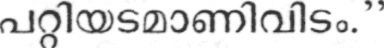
പറ്റിയടമാണിവിടം."
